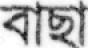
বাছা
